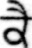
ਕੈ
